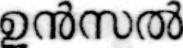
ഉന്‍സല്‍
